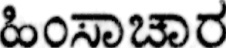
ಹಿಂಸಾಚಾರ
